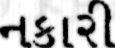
નકારી
